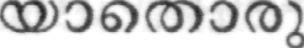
യാതൊരു
